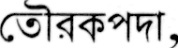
তৌরকপদা,
